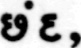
છંદ,
